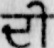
ਦੀ
